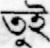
তুই
